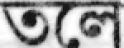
তলে
